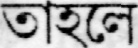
তাহলে
